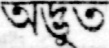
অদ্ভুত
